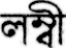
লম্বী
